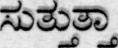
ಸುತ್ತುತ್ತಾ
